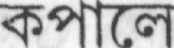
কপালে
